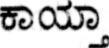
ಕಾಯ್ತಾ
